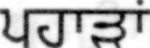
ਪਹਾੜਾਂ
